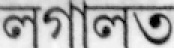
লগালত
